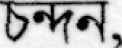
চন্দন,
